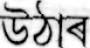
উঠাৰ
